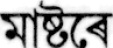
মাষ্টৰে
